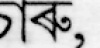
চাৰু,
